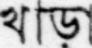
খাড়া
